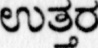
ಉತ್ತರ
